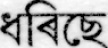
ধৰিছে
